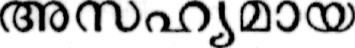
അസഹ്യമായ
